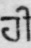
ਹੀ
